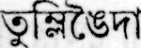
তুম্লিঙৈদা
